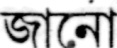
জানো
